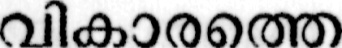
വികാരത്തെ
